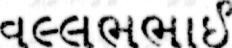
વલ્લભભાઈ
